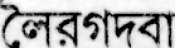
লৈরগদবা
